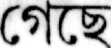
গেছে
